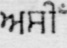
ਅਸੀਂ
